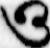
ও
